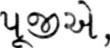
પૂજીએ,
